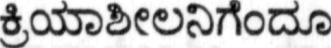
ಕ್ರಿಯಾಶೀಲನಿಗೆಂದೂ
